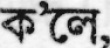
ক'লে,
